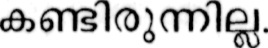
കണ്ടിരുന്നില്ല.
